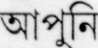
আপুনি
